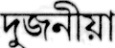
দুজনীয়া
